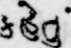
કહેતું
